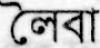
লৈবা
